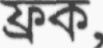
ফ্রক,
